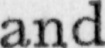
and
